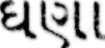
ઘણા
